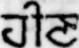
ਹੀਣ
